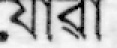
যোৱা
